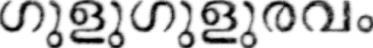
ഗുളുഗുളുരവം
